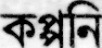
কপ্পনি
